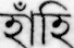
হাঁহি
